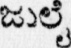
ಜುಲೈ
